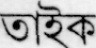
তাইক
